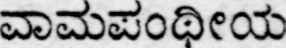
ವಾಮಪಂಥೀಯ
